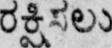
ರಕ್ಷಿಸಲು
